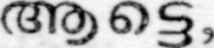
ആട്ടെ,
